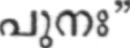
പുനഃ”
